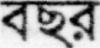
বছর
